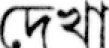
দেখা
